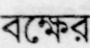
বক্ষের
